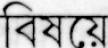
বিষয়ে
